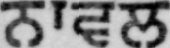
ਨਾਵਲ
